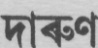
দাৰুণ
